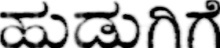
ಹುಡುಗಿಗೆ
